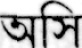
অসি
